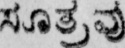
ಸೂತ್ರವು
